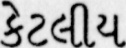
કેટલીય
